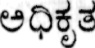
ಅಧಿಕೃತ
